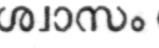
ശ്വാസം
